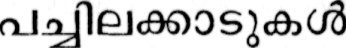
പച്ചിലക്കാടുകള്‍
